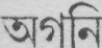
অগনি
